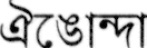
ঐঙোন্দা
